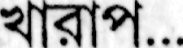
খারাপ...
